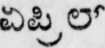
ಏಪ್ರಿಲ್
